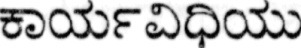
ಕಾರ್ಯವಿಧಿಯು
